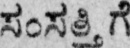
ಸಂಸತ್ತಿಗೆ
